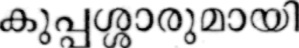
കുപ്പശ്ശാരുമായി
